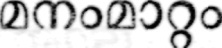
മനംമാറ്റം
